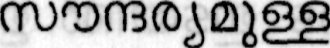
സൌന്ദര്യമുള്ള
